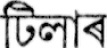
টিলাৰ
